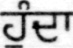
ਹੁੰਦਾ
